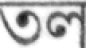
তল
